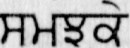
ਸਮਝਕੇ
